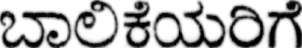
ಬಾಲಿಕೆಯರಿಗೆ
